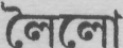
লৈলো
